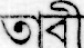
তাবী
